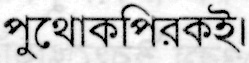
পুথোকপিরকই।
